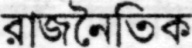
রাজনৈতিক
